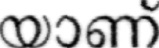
യാണ്
